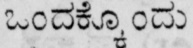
ಒಂದಕ್ಕೊಂದು
